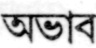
অভাব
